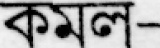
কমল-
